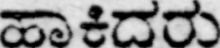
ಹಾಕಿದರು
